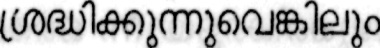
ശ്രദ്ധിക്കുന്നുവെങ്കിലും
